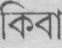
কিবা
